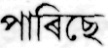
পাৰিছে
